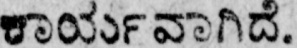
ಕಾರ್ಯವಾಗಿದೆ.
